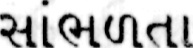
સાંભળતા
